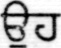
ਉਹ
